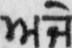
ਅਜੇ
